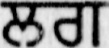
ਲਗ
